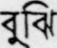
বুঝি
